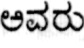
ಅವರು
